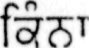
ਕਿੰਨਾ
